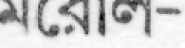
মরোল-
